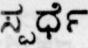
ಸ್ಪರ್ಧೆ
